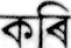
কৰি
